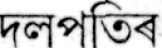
দলপতিৰ
